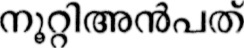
നൂറ്റിഅന്‍പത്
